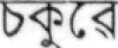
চকুৱে
